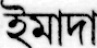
ইমাদা
